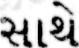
સાથે
